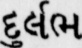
દુર્લભ
